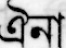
ঐনা
